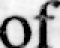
of
